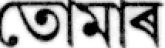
তোমাৰ
